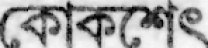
কোকশেৎ
